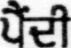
ਪੈਂਦੀ
